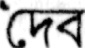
দেব
